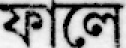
ফালে
